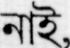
নাই,
